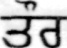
ਤੌਰ
